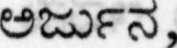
ಅರ್ಜುನ,
